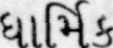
ધાર્મિક
